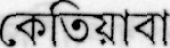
কেতিয়াবা
